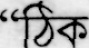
"ঠিক
